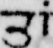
ਤਾਂ
